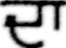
ਦਾ
